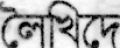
লৈখিদে
